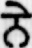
ਨੇ
